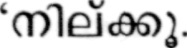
‘നില്ക്കൂ.
